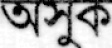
অসুক
